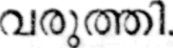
വരുത്തി.
